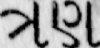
ત્રણ
